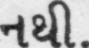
નથી.
